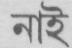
নাই
